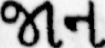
જાન
